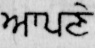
ਆਪਣੇ
